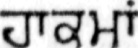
ਹਾਕਮਾਂ
